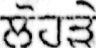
ਲੋਹੜੇ
